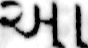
આ
